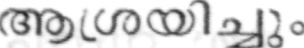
ആശ്രയിച്ചും
